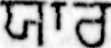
ਯਾਰ
